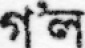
গ'ল
